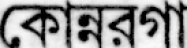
কোন্নরগা
